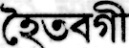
হৈতবগী
